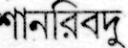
শানরিবদু
